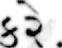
કરે.
